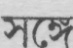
সঙ্গে
